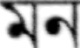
মন
